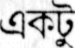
একটু
